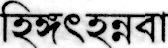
হিঙ্গৎহন্নবা
